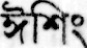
ঈশিং
